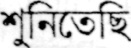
শুনিতেছি
